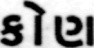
કોણ
